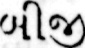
બીજી
